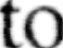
to
